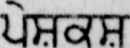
ਪੇਸ਼ਕਸ਼
